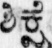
ಶಿಕ್ಷೆ
